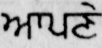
ਆਪਣੇ
